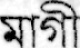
মাগী
